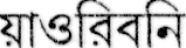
য়াওরিবনি
